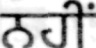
ਨਹੀਂ
